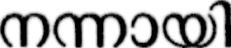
നന്നായി
